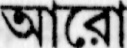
আরো
